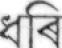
ধৰি
